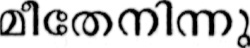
മീതേനിന്നു
